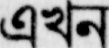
এখন
